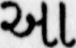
આ
